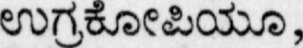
ಉಗ್ರಕೋಪಿಯೂ,
